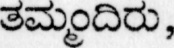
ತಮ್ಮಂದಿರು,
